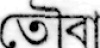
তৌবা
